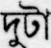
দুটা
